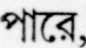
পারে,
